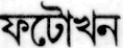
ফটোখন
